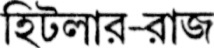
হিটলার-রাজ
